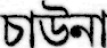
চাউনা
